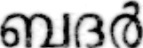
ബദര്‍
